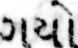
ગયો
